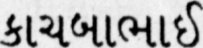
કાચબાભાઈ
